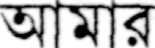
আমার
